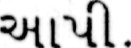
આપી.
